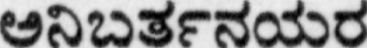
ಅನಿಬರ್ತನಯರ
